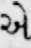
એ
